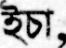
ইচা,
